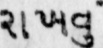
રાખવું
